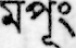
মপূং
